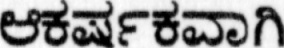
ಆಕರ್ಷಕವಾಗಿ
